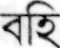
বহি
